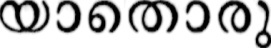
യാതൊരു
